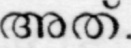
അത്.
